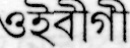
ওইবীগী
